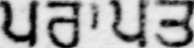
ਪਰਾਪਤ
